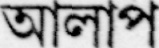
আলাপ
